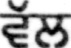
ਵੱਲ
